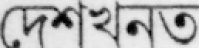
দেশখনত
